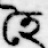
হৈ
